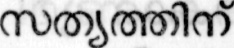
സത്യത്തിന്
